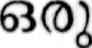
ഒരു
